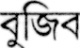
বুজিব
